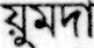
য়ুমদা
